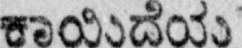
ಕಾಯಿದೆಯ
